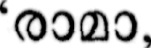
‘രാമാ,
